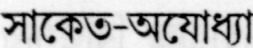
সাকেত-অযোধ্যা
